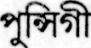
পুন্সিগী
